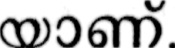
യാണ്.
